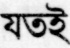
যতই
